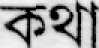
কথা
